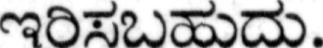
ಇರಿಸಬಹುದು.
